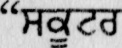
''ਸਕੂਟਰ
